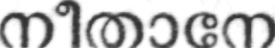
നീതാനേ
